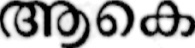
ആകെ
